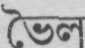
ভৈল
